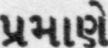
પ્રમાણે
